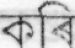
কৰি
